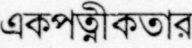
একপত্নীকতার
